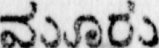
ಮೂರು
